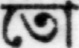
তো
